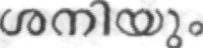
ശനിയും
